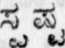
ಸ್ಪಷ್ಟ
